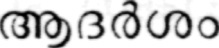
ആദര്‍ശം
